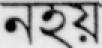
নহয়
